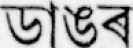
ডাঙৰ
